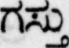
ಗಸ್ತು
